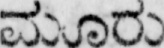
ಮೂರು
